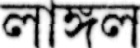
লাঙ্গল
